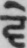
ਵੇ
